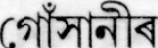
গোঁসানীৰ
